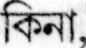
কিনা,
